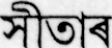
সীতাৰ
